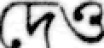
দেও
